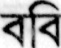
ববি
